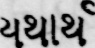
યથાર્થ
